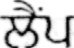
ਲੈਂਪ
